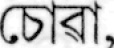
চোৱা,
